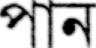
পান
